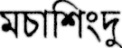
মচাশিংদু
